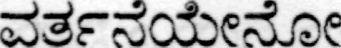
ವರ್ತನೆಯೇನೋ
